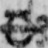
ಈ
